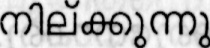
നില്ക്കുന്നു
